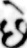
છે
